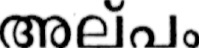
അല്പം
